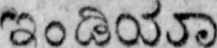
ಇಂಡಿಯಾ
